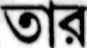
তার
